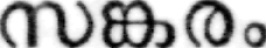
സങ്കരം
